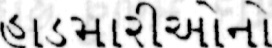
હાડમારીઓનો
